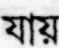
যায়
